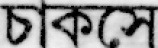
চাকসে
